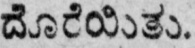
ದೊರೆಯಿತು.
